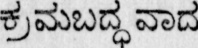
ಕ್ರಮಬದ್ಧವಾದ
